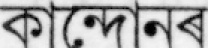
কান্দোনৰ
